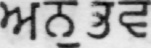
ਅਨੁਭਵ
